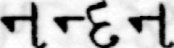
નન્દન
